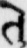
તે
